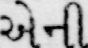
એની
